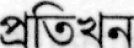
প্রতিখন
